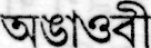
অঙাওবী
